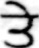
ਤੇ
